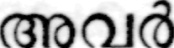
അവര്‍
